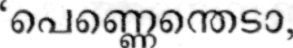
'പെണ്ണെന്തെടാ,
